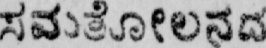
ಸಮತೋಲನದ
